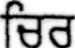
ਚਿਰ
